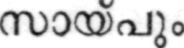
സായ്പും
